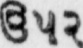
ઉપર
